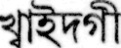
খ্বাইদগী
